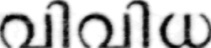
വിവിധ
